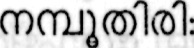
നമ്പൂതിരി:
